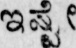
ಇಷ್ಟೇ
